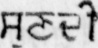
ਸੁਣਦੀ
